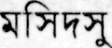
মসিদসু
